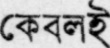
কেবলই
